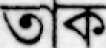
তাক
